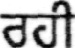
ਰਹੀ
